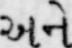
અને
